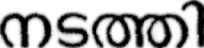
നടത്തി
